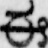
ಈ
